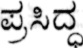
ಪ್ರಸಿದ್ಧ
